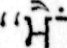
''ਮੈਂ
